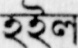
হইল
